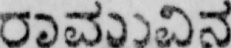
ರಾಮುವಿನ
